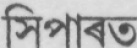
সিপাৰত
